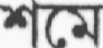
শমে
